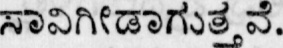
ಸಾವಿಗೀಡಾಗುತ್ತವೆ.
